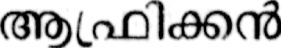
ആഫ്രിക്കന്‍
